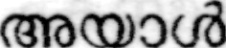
അയാള്‍
